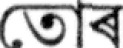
তোৰ
